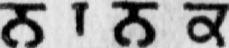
ਨਾਨਕ
